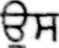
ਉਸ
